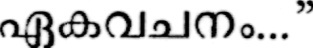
ഏകവചനം..."
